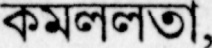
কমললতা,
